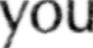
you
